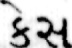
કેસ
